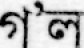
গ'ল
